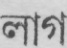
লাগ
